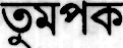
তুমপক
